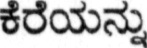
ಕೆರೆಯನ್ನು
